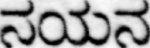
ನಯನ
